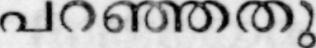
പറഞ്ഞതു
